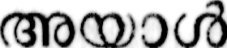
അയാള്‍
